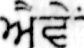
ਐਵੇਂ
